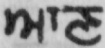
ਆਣ
